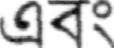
এবং
